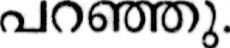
പറഞ്ഞു.
